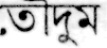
তৌদুম
